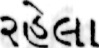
રહેલા
